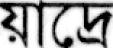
য়াদ্রে
